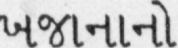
ખજાનાનો
